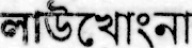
লাউখোংনা
